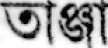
তাঞ্জা
